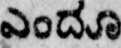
ಎಂದೂ
